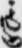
હું
